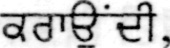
ਕਰਾਉਂਦੀ,
